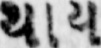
થાય
